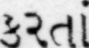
કરતાં
